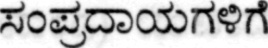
ಸಂಪ್ರದಾಯಗಳಿಗೆ
